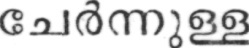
ചേര്‍ന്നുള്ള
